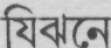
যিঝনে
